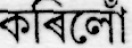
কৰিলোঁ
